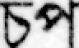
চপ
